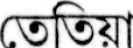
তেতিয়া
